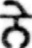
ਨੇ
